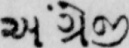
અંગ્રેજી
